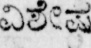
ವಿಶೇಷ
